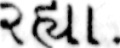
રહ્યા.
